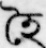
হৈ
